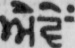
ਐਵੇਂ
